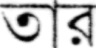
তার
